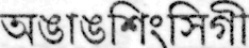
অঙাঙশিংসিগী
